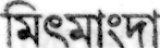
মীৎমাংদা
